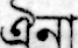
ঐনা
